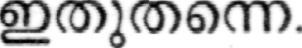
ഇതുതന്നെ.
